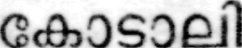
കോടാലി
